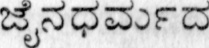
ಜೈನಧರ್ಮದ
